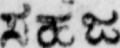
ಸಹಜ
